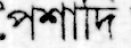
পৈশাদি
